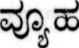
ವ್ಯೂಹ
